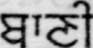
ਬਾਣੀ
